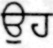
ਉਹ
